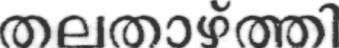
തലതാഴ്ത്തി
